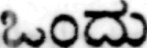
ಒಂದು
